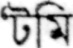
‘টমি
